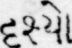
દ્દશ્યો
